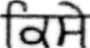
ਕਿਸੇ
